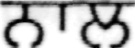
ਨਾਲ
